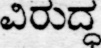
ವಿರುದ್ಧ
